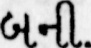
બની.
